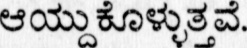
ಆಯ್ದುಕೊಳ್ಳುತ್ತವೆ.
